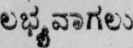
ಲಭ್ಯವಾಗಲು
